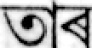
তাৰ
